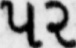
પર
